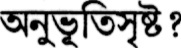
অনুভূতিসৃষ্ট?
